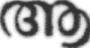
ആ
